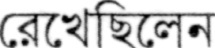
রেখেছিলেন
